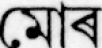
মোৰ
